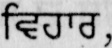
ਵਿਹਾਰ,
